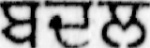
ਬਦਲ
